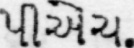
પીએચ.
